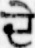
ਦੇ
